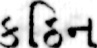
કઠિન
